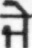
ਜੇ
